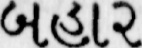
બહાર
